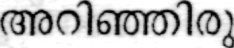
അറിഞ്ഞിരു
